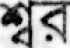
শ্বর
